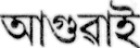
আগুৱাই
